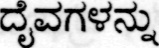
ದೈವಗಳನ್ನು
